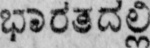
ಭಾರತದಲ್ಲಿ
